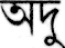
অদু
